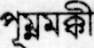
পূম্নমক্কী
